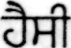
ਹੈਸੀ
